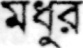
মধুর
